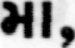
મા,
